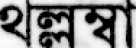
থল্লম্বা
